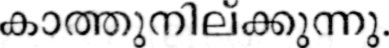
കാത്തുനില്ക്കുന്നു.
